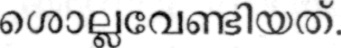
ശൊല്ലവേണ്ടിയത്.
